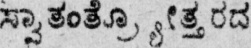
ಸ್ವಾತಂತ್ರ್ಯೋತ್ತರದ
